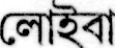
লোইবা
